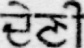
ਦੇਣੀ
